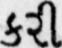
કરી
